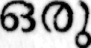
ഒരു
